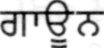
ਗਾਊਨ
